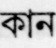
কান
